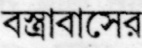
বস্ত্রাবাসের
